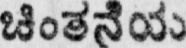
ಚಿಂತನೆಯ
